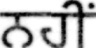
ਨਹੀਂ
